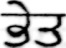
ਭੇਤ
